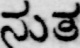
ನುತ
